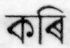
কৰি
